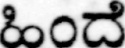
ಹಿಂದೆ
